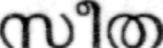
സീത
